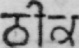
ਠੀਕ
